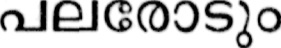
പലരോടും
